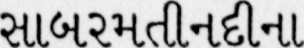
સાબરમતીનદીના
